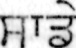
ਸਾਡੇ
